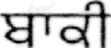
ਬਾਕੀ
